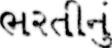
ભરતીનું
